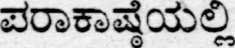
ಪರಾಕಾಷ್ಠೆಯಲ್ಲಿ
